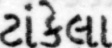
ટાંકેલા
